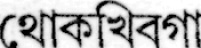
থোকখিবগা
